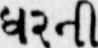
ધરની
